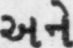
અને
